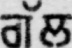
ਗੱਲ
